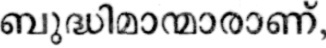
ബുദ്ധിമാന്മാരാണ്,
